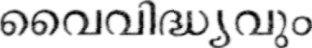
വൈവിദ്ധ്യവും
